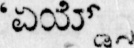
‘ಏಂii
